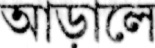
আড়ালে
